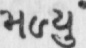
મળ્યું
